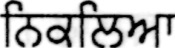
ਨਿਕਲਿਆ
